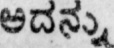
ಅದನ್ನು
